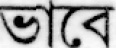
ভাবে
